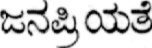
ಜನಪ್ರಿಯತೆ
